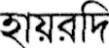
হায়রদি
